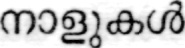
നാളുകള്‍
